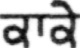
ਕਾਕੇ
